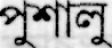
পুশালু
